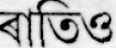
ৰাতিও
